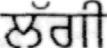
ਲੱਗੀ
